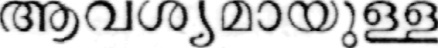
ആവശ്യമായുള്ള
